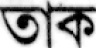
তাক
